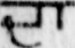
ਦਾ
